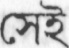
সেই
